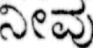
ನೀವು
